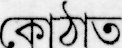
কোঠাত
